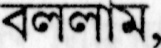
বললাম,
